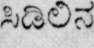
ಸಿಡಿಲಿನ
